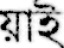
য়াই
